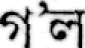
গ'ল
